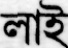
লাই
